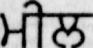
ਮੀਲ
